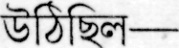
উঠিছিল-
